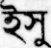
ইসু
